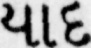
યાદ
